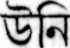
উনি
